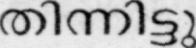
തിന്നിട്ടു
